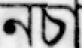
নচা
